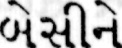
બેસીને
